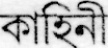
কাহিনী
